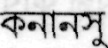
কনানসু
